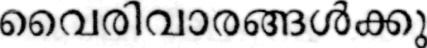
വൈരിവാരങ്ങള്‍ക്കു
